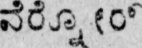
ವೆರ್‍ನೋರ್
